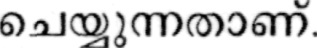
ചെയ്യുന്നതാണ്.
